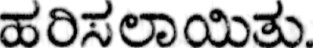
ಹರಿಸಲಾಯಿತು.
